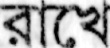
রাখে
